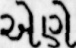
એણે
